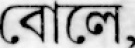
বোলে,
